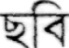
ছবি
